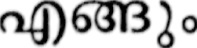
എങ്ങും
